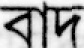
বাদ
